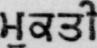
ਮੁਕਤੀ
